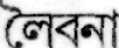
লৈবনা
